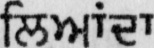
ਲਿਆਂਦਾ
